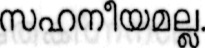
സഹനീയമല്ല.
